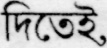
দিতেই,
